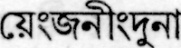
য়েংজনীংদুনা
